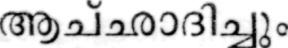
ആച്ഛാദിച്ചും
